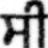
ਸੀ
